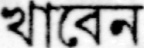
খাবেন
